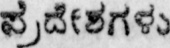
ಪ್ರದೇಶಗಳು
